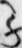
કે
